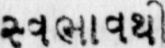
સ્વભાવથી
